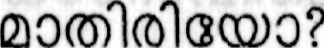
മാതിരിയോ?
